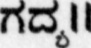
ಗದ್ಯ||
